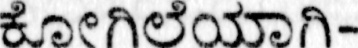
ಕೋಗಿಲೆಯಾಗಿ-
